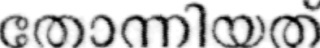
തോന്നിയത്
